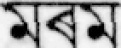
মৰম
